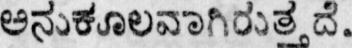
ಅನುಕೂಲವಾಗಿರುತ್ತದೆ.
